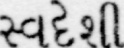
સ્વદેશી
